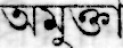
অমুক্তা
